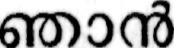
ഞാന്‍
